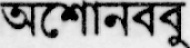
অশোনববু
